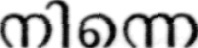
നിന്നെ
